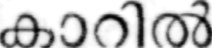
കാറില്‍
